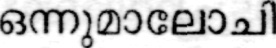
ഒന്നുമാലോചി
